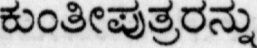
ಕುಂತೀಪುತ್ರರನ್ನು
